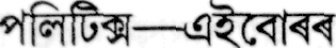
পলিটিক্স-এইবোৰৰ
